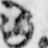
છે.
